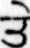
ਤੇ
